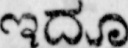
ಇದೂ
